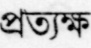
প্রত্যক্ষ
